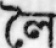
লৈ
